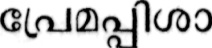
പ്രേമപ്പിശാ
